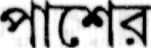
পাশের
